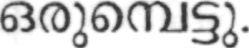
ഒരുമ്പെട്ടു.
